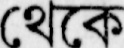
থেকে
